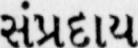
સંપ્રદાય
